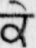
ਕੇ
